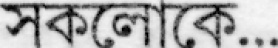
সকলোকে...
